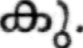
കു.
